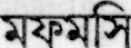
মফমসি
